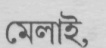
মেলাই,
